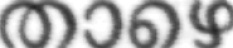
താഴെ
